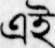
এই
